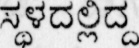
ಸ್ಥಳದಲ್ಲಿದ್ದ
